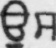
ਉਸ
